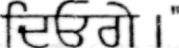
ਦਿਓਗੇ।''
